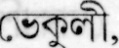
ভেকুলী,
